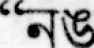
“নঙ
